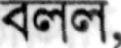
বলল,
